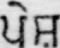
ਪੇਸ਼
